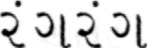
રંગરંગ
